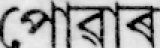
পোৱাৰ
